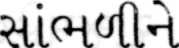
સાંભળીને
